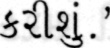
કરીશું.'
